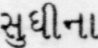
સુધીના
